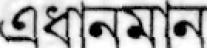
এধানমান
